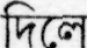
দিলে
